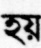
হয়
